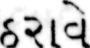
ઠરાવે
